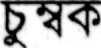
চুম্বক
